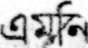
এমনি
